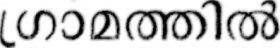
ഗ്രാമത്തില്‍
